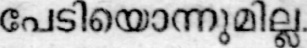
പേടിയൊന്നുമില്ല.
